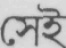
সেই
